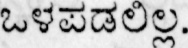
ಒಳಪಡಲಿಲ್ಲ.
